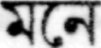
মনে
